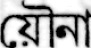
য়ৌনা
